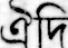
ঐদি
